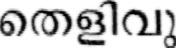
തെളിവു
